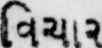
વિચાર
